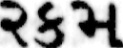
રકમ
